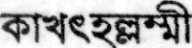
কাখৎহল্লম্মী
